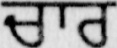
ਚਾਰ
